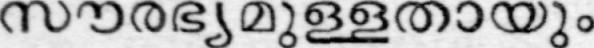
സൌരഭ്യമുള്ളതായും
